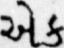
એક
